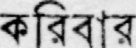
করিবার
